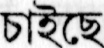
চাইছে
